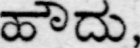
ಹೌದು,
